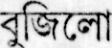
বুজিলো
